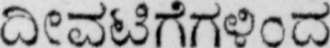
ದೀವಟಿಗೆಗಳಿಂದ
